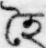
হৈ
